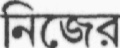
নিজের
